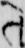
તે
